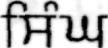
ਸਿੰਘ
